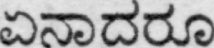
ಏನಾದರೂ
